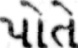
પોતે
